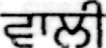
ਵਾਲੀ
